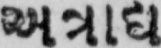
અત્રાધ
